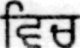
ਵਿਚ
